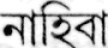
নাহিবা
